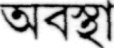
অবস্থা
